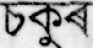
চকুৰ
